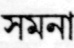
সমনা
